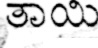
ತಾಯಿ
